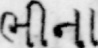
ભીના
